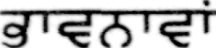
ਭਾਵਨਾਵਾਂ
